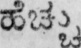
ಹೆಚ್ಚು
